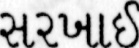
સરખાઈ
